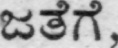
ಜತೆಗೆ,
